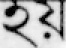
হয়
